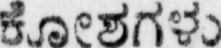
ಕೋಶಗಳು
